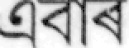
এবাৰ
